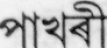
পাখৰী
